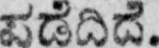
ಪಡೆದಿದೆ.
